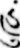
હું
